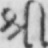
શ્રી
